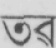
তৱ
